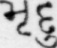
મૃદુ
